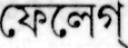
ফেলেগ
